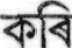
কৰি
